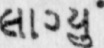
લાગ્યું
